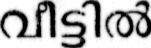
വീട്ടില്‍
